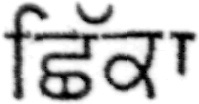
ਛਿੱਕਾ
